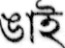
ঙাই
